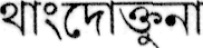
থাংদোক্তুনা
